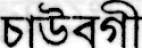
চাউবগী
